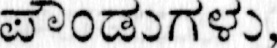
ಪೌಂಡುಗಳು,
